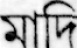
মাদি
